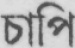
চাপি
